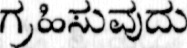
ಗ್ರಹಿಸುವುದು
